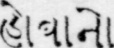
હોવાનો
